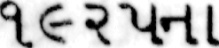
૧૯૨૫ના
